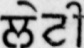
ਲੇਟੀ
